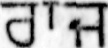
ਰਾਜ
